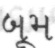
બૂમ
